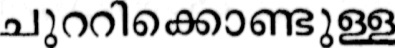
ചുററിക്കൊണ്ടുള്ള
